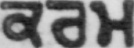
ਕਰਮ
